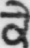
ਕੇ
